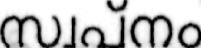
സ്വപ്നം
